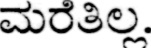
ಮರೆತಿಲ್ಲ.
